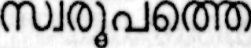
സ്വരൂപത്തെ
